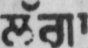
ਲੱਗਾ
